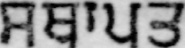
ਸਥਾਪਤ
